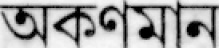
অকণমান
